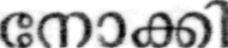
നോക്കി
